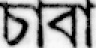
তাবা
